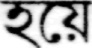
হয়ে
